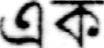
এক
